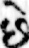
છે
